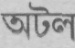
অটল
